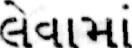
લેવામાં
